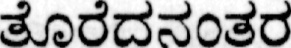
ತೊರೆದನಂತರ
